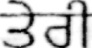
ਤੇਰੀ
